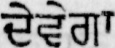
ਦੇਵੇਗਾ
